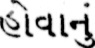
હોવાનું
